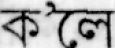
ক'লে
